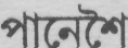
পানেশৈ
